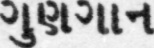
ગુણગાન
